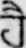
ਹੈ
